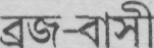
ব্ৰজ-বাসী
